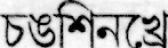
চঙশিনখ্রে
